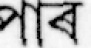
পাৰ
